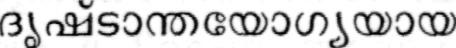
ദൃഷ്ടാന്തയോഗ്യയായ
